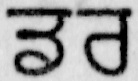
ਡਰ
